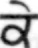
ਕੇ
